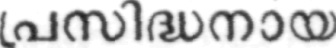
പ്രസിദ്ധനായ
